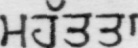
ਮਹੱਤਤਾ
